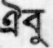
ঐবু
